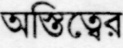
অস্তিত্বের
